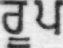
ਰੂਪ
